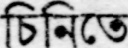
চিনিতে
